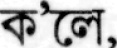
ক'লে,
